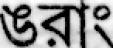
ঙরাং
